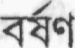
বর্ষণ
